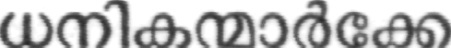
ധനികന്മാര്‍ക്കേ
